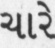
ચારે
